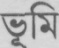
ভূমি
